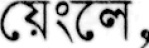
য়েংলে,
